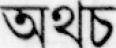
অথচ
